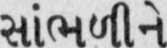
સાંભળીને
